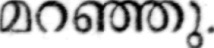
മറഞ്ഞു.
